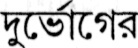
দুর্ভোগের
